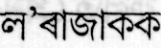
ল'ৰাজাকক
